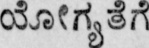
ಯೋಗ್ಯತೆಗೆ
